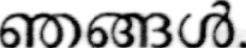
ഞങ്ങള്‍.
